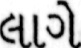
લાગે
